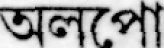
অলপো
